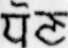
ਧੋਣ
